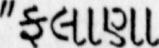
"ફલાણા
